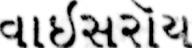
વાઇસરૉય
